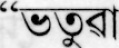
"ভতুৱা
